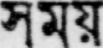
সময়
